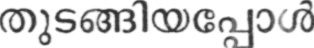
തുടങ്ങിയപ്പോള്‍
